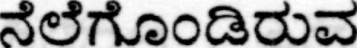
ನೆಲೆಗೊಂಡಿರುವ
